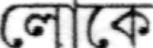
লোকে
